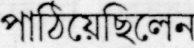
পাঠিয়েছিলেন
